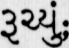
રૂચ્યું.
